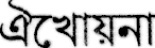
ঐখোয়না
